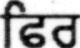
ਫਿਰ
